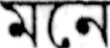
মনে
